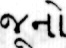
જૂનો
